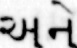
અને
